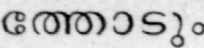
ത്തോടും
